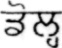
ਡੋਲ੍ਹ
